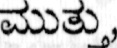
ಮುತ್ತು,
